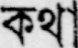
কথা
